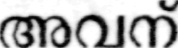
അവന്
